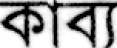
কাব্য
